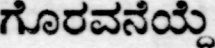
ಗೊರವನೆಯ್ದೆ
